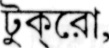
টুক্রো,
